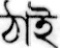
ঠাই
